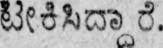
ಟೀಕಿಸಿದ್ದಾರೆ.
